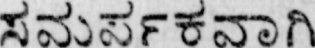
ಸಮರ್ಪಕವಾಗಿ
